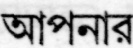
আপনার
